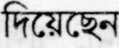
দিয়েছেন
